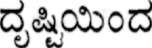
ದೃಷ್ಟಿಯಿಂದ
